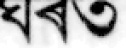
ঘৰত
